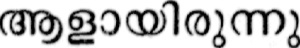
ആളായിരുന്നു
